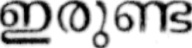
ഇരുണ്ട
